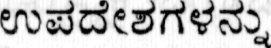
ಉಪದೇಶಗಳನ್ನು
